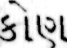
કોણ
